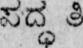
ಪದ್ಧತಿ
